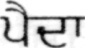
ਪੈਦਾ
